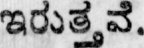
ಇರುತ್ತವೆ.
